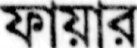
ফায়ার
